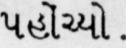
પહોંચ્યો.
